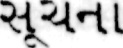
સૂચના
